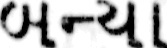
બન્યા
